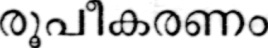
രൂപീകരണം
